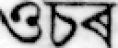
ওচৰ
